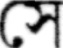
সে
